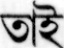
তাই
